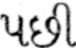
પછી
